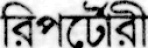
রিপটোরী
